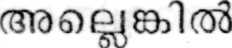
അല്ലെങ്കില്‍
